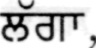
ਲੱਗਾ,
